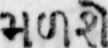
મળશે
